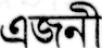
এজনী
